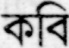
কবি
